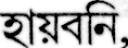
হায়বনি,
